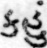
કહું
